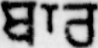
ਬਾਰ
